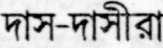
দাস-দাসীরা
